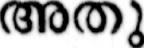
അതു
